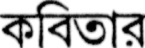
কবিতার
